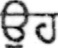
ਉਹ
